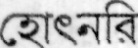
হোৎনরি
